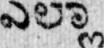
ಎಲ್ಲಾ
